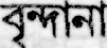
বৃন্দাদা
